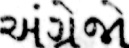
અંગ્રેજો
